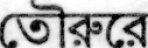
তৌরুরে
